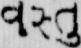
વસ્તુ
